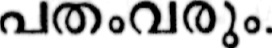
പതംവരും.
